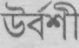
উৰ্বশী
